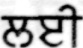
ਲਈ
